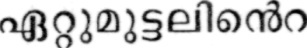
ഏറ്റുമുട്ടലിന്റെ
